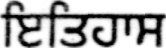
ਇਤਿਹਾਸ
